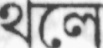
থলে
